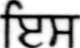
ਇਸ
